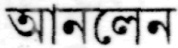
আনলেন
